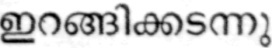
ഇറങ്ങിക്കടന്നു
